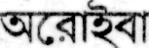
অরোইবা
